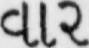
વાર
